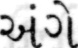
અંગે
